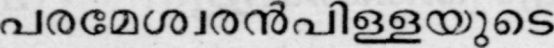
പരമേശ്വരന്‍പിള്ളയുടെ
